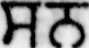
ਸਨ
